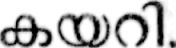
കയറി.
